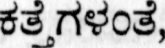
ಕತ್ತೆಗಳಂತೆ,
